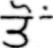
ਤੋਂ
